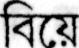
বিয়ে
